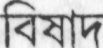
বিষাদ
